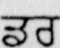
ਡਰ
